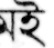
মই
